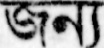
জন্য
